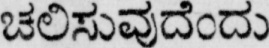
ಚಲಿಸುವುದೆಂದು
